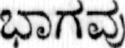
ಭಾಗವು
